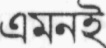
এমনই
